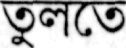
তুলতে
